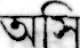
অসি
